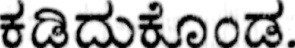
ಕಡಿದುಕೊಂಡ.
